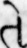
તે
